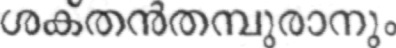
ശക്തന്‍തമ്പുരാനും
